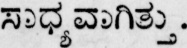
ಸಾಧ್ಯವಾಗಿತ್ತು.
